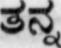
ತನ್ನ
